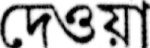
দেওয়া
